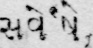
સર્વેષે,
